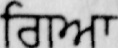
ਗਿਆ
